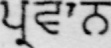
ਪ੍ਰਵਾਨ
